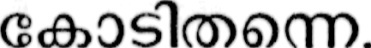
കോടിതന്നെ.
